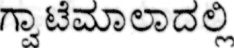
ಗ್ವಾಟೆಮಾಲಾದಲ್ಲಿ
